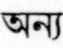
অন্য
